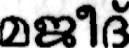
മജീദ്
